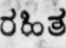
ರಹಿತ
